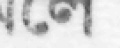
মেলে
